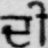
ਦੀ
